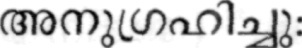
അനുഗ്രഹിച്ചു:
